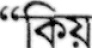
"কিয়
